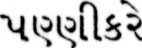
પણ્ણીકરે
